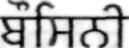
ਬੌਸਿਨੀ
